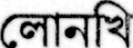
লোনখি
